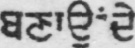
ਬਣਾਉਂਦੇ
